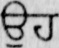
ਉਹ
